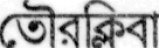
তৌরক্লিবা
